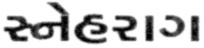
સ્નેહરાગ
